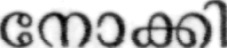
നോക്കി
